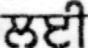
ਲਈ
